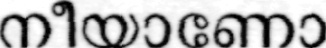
നീയാണോ
